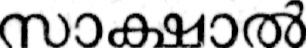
സാക്ഷാല്‍
